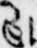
હો
